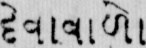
દેવાવાળો
